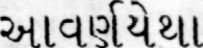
આવર્ણયેથા
